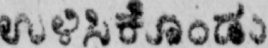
ಉಳಿಸಿಕೊಂಡು
